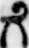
ಗೆ
